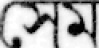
সেম
